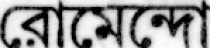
রোমেন্দো
